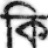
কি
